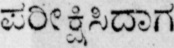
ಪರೀಕ್ಷಿಸಿದಾಗ
